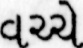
વચ્ચે
